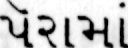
પૅરામાં
